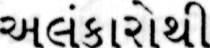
અલંકારોથી
